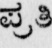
ಪ್ರತಿ
